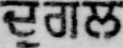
ਦੁਗਲ
